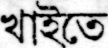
খাইতে
